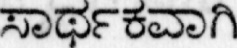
ಸಾರ್ಥಕವಾಗಿ
